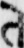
તે
